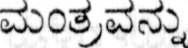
ಮಂತ್ರವನ್ನು
